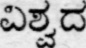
ವಿಶ್ವದ
